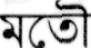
মতৌ
